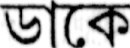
ডাকে
